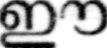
ഈ
